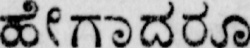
ಹೇಗಾದರೂ
